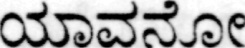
ಯಾವನೋ
